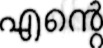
എന്റെ
